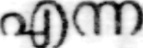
എന്ന
